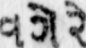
વગેરે
